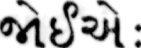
જોઈએઃ
